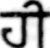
ਹੀ
